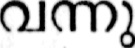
വന്നു
